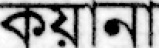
কয়ানা
